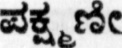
ಪಕ್ಷ್ಮಣೀ
